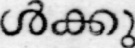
ള്‍ക്കു
